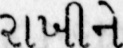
રાખીને
